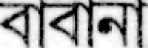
বাবানা
